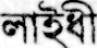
লাইধী
